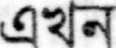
এখন
